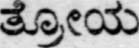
ತ್ರೋಯ
